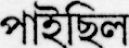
পাইছিল
